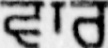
ਵਾਰ
